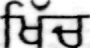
ਖਿੱਚ
